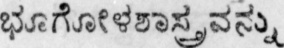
ಭೂಗೋಳಶಾಸ್ತ್ರವನ್ನು
